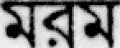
মরম
